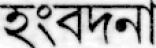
হংবদনা
